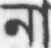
না
